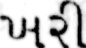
ખરી
